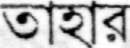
তাহার
